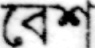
বেশ
